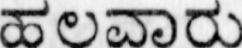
ಹಲವಾರು
